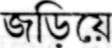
জড়িয়ে
